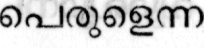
പെരുളെന്ന
